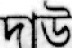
দাউ
